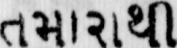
તમારાથી
